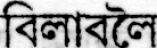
বিলাবলৈ
